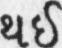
થઈ
